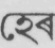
হেৰ
